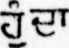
ਹੁੰਦਾ
